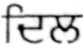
ਦਿਲ
